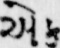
એક
